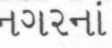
નગરનાં
